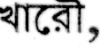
খারৌ,
